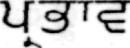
ਪ੍ਰਭਾਵ
